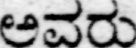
ಅವರು
